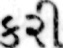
કરી
